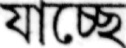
যাচ্ছে
